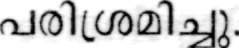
പരിശ്രമിച്ചു.
